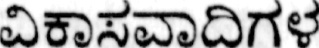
ವಿಕಾಸವಾದಿಗಳ
